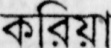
করিয়া
